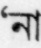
‘না
